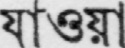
যাওয়া
